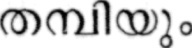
തമ്പിയും
